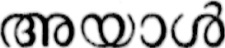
അയാള്‍
